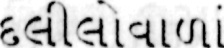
દલીલોવાળાં
